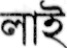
লাই
